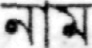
নাম
